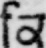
ਕਿ
